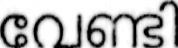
വേണ്ടി
